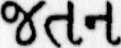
જતન
